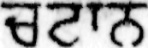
ਚਟਾਨ
